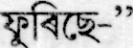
ফুৰিছে-"
